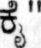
ಕೈ’
